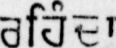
ਰਹਿੰਦਾ
